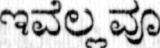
ಇವೆಲ್ಲವೂ
